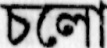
চলো
